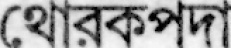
থোরকপদা
